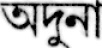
অদুনা
